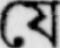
যে
